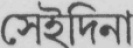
সেইদিনা
